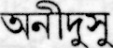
অনীদুসু
